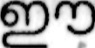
ഈ
